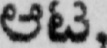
ಆಟ,
